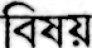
বিষয়
